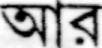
আর
